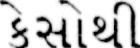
કેસોથી
